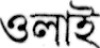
ওলাই
